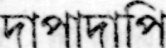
দাপাদাপি
